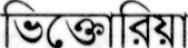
ভিক্তোরিয়া
